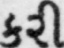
કરી
